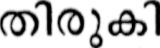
തിരുകി
